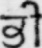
ਭੀ
